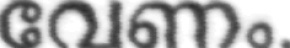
വേണം.
